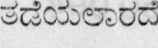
ತಡೆಯಲಾರದೆ
